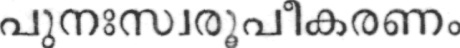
പുനഃസ്വരൂപീകരണം
